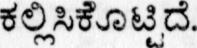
ಕಲ್ಪಿಸಿಕೊಟ್ಟಿದೆ.
